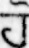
ਹੋ
